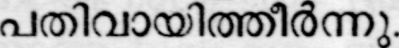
പതിവായിത്തീര്‍ന്നു.
